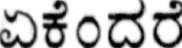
ಏಕೆಂದರೆ
